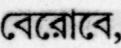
বেরোবে,
